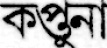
কপ্তুনা
